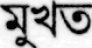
মুখত
